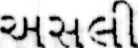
અસલી
